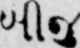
બીજુ
